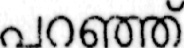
പറഞ്ഞ്
